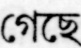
গেছে
